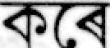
কৰে
